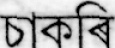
চাকৰি
